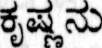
ಕೃಷ್ಣನು
